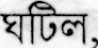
ঘটিল,
